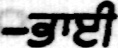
-ਭਾਈ
